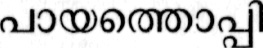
പായത്തൊപ്പി
